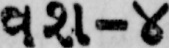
વશ-૪
